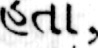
હતા,
